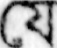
যে
